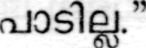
പാടില്ല.”
